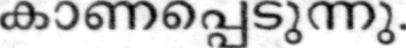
കാണപ്പെടുന്നു.
